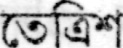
তেত্রিশ
